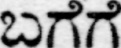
ಬಗೆಗೆ
